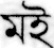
মই
